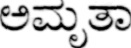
ಅಮೃತಾ
